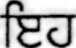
ਇਹ
